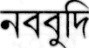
নববুদি
